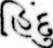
હિંદુ
